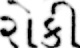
રોકી
